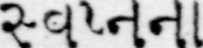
સ્વપ્નના
